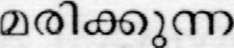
മരിക്കുന്ന
